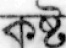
কষ্ট
